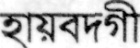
হায়বদগী
